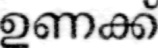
ഉണക്ക്
